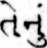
તેનું
